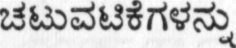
ಚಟುವಟಿಕೆಗಳನ್ನು
